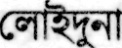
লৌইদুনা
